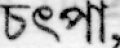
চৎপা,
